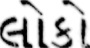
લોકો
